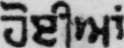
ਹੋਈਆਂ
